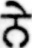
ਨੇ
